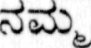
ನಮ್ಮ
